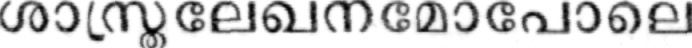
ശാസ്ത്രലേഖനമോപോലെ
